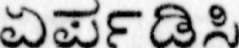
ಏರ್ಪಡಿಸಿ
